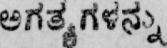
ಅಗತ್ಯಗಳನ್ನು
